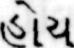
હોય
